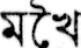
মখৈ
